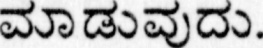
ಮಾಡುವುದು.
